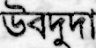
উবদুদা
